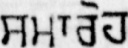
ਸਮਾਰੋਹ
